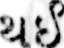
થઈ
